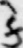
કે
